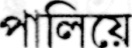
পালিয়ে
